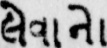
લેવાનો
